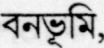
বনভূমি,
